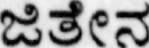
ಜಿತೇನ
